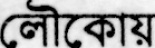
লৌকোয়
